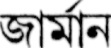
জার্মান
